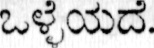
ಒಳ್ಳೆಯದೆ.
